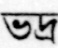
ভদ্র
